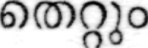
തെറ്റും
